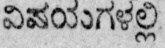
ವಿಷಯಗಳಲ್ಲಿ
